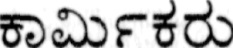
ಕಾರ್ಮಿಕರು
